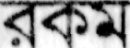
রকম
